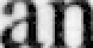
an
